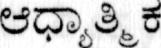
ಆಧ್ಯಾತ್ಮಿಕ
